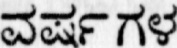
ವರ್ಷಗಳ
